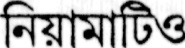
নিয়ামাটিও
